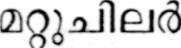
മറ്റുചിലര്‍
